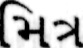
મિત્ર
